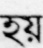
হয়
